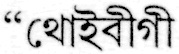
“থোইবীগী
